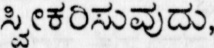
ಸ್ವೀಕರಿಸುವುದು,
